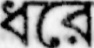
ধরে
